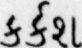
કર્કશ
